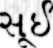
સૂઈ
